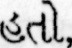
હતો,
